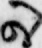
જે
